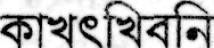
কাখৎখিবনি
